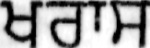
ਖਰਾਸ
